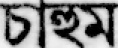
চাহুম
